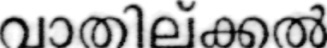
വാതില്ക്കല്‍
